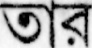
তার
